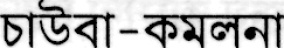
চাউবা-কমলনা
